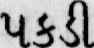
પકડી
